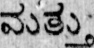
ಮತ್ತು
